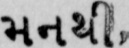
મનથી,
